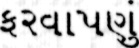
ફરવાપણું
